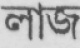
লাজ
